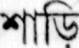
শাড়ি
